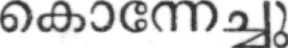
കൊന്നേച്ചു
